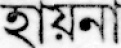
হায়না
